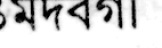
ঙমদবগী
